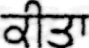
ਕੀਤਾ
